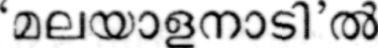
‘മലയാളനാടി’ല്‍
